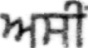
ਅਸੀਂ
